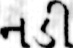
નડી
